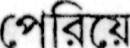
পেরিয়ে
